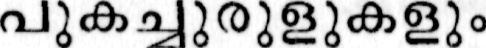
പുകച്ചുരുളുകളും
